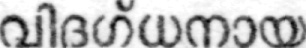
വിദഗ്ധനായ
